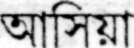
আসিয়া
